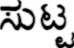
ಸುಟ್ಟ
